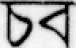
চব
